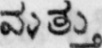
ಮತ್ತು
